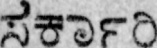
ಸರ್ಕಾರಿ
